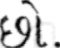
છો.
